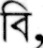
বি,
